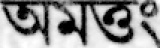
অমত্তং
